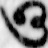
ও
